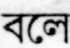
বলে
